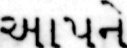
આપને
